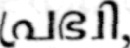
പ്രഭ്വി,
